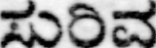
ಸುರಿವ
